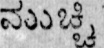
ಮುಚ್ಚಿ
